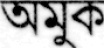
অমুক
